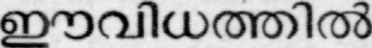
ഈവിധത്തില്‍
